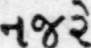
નજરે
